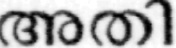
അതി
